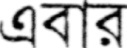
এবার
